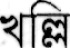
খল্লি
